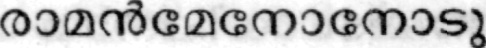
രാമന്‍മേനോനോടു
